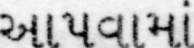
આપવામાં
